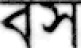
বস
